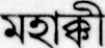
মহাক্কী
